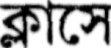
ক্লাসে
